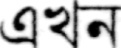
এখন
